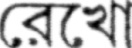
রেখো
